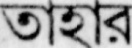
তাহার
